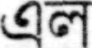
এল
